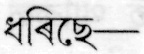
ধৰিছে-
